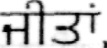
ਜੀਤਾਂ,
